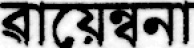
ৱায়েম্বনা
